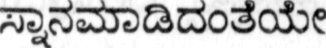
ಸ್ನಾನಮಾಡಿದಂತೆಯೇ
